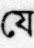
যে
